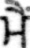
ਮੈਂ
